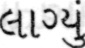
લાગ્યું
